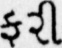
ફરી
